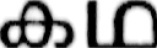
കഥ
